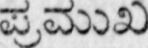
ಪ್ರಮುಖ
